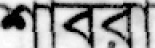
শাবরা
